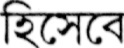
হিসেবে
